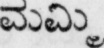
ಮಮ್ಮಿ
